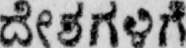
ದೇಶಗಳಿಗೆ
